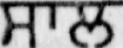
ਸਾਲ
